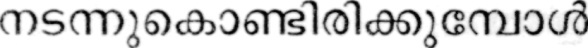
നടന്നുകൊണ്ടിരിക്കുമ്പോള്‍
